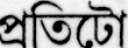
প্রতিটো
